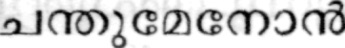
ചന്തുമേനോന്‍
